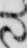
ನ
